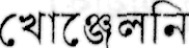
খোঞ্জেলনি
